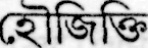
হৌজিক্তি
